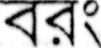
বরং
